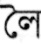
লৈ
